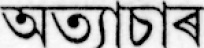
অত্যাচাৰ
